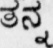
ತನ್ನ
